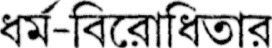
ধর্ম-বিরোধিতার
